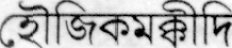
হৌজিকমক্কীদি
